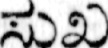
ಸುಖ
